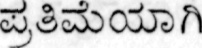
ಪ್ರತಿಮೆಯಾಗಿ
